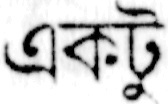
একটু
